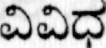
ವಿವಿಧ
